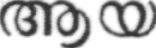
ആയ
